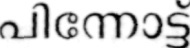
പിന്നോട്ട്
